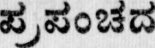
ಪ್ರಪಂಚದ
